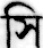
সি
